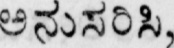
ಅನುಸರಿಸಿ,
